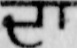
ਦਾ
